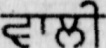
ਵਾਲੀ
